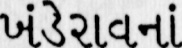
ખંડેરાવનાં
